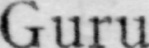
Guru
